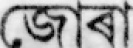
জোৰা
